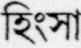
হিংসা
